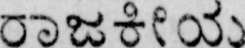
ರಾಜಕೀಯ
